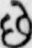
છે
